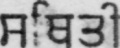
ਸਥਿਤੀ
